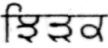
ਝਿੜਕ
